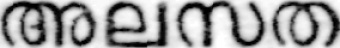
അലസത
